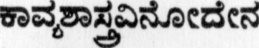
ಕಾವ್ಯಶಾಸ್ತ್ರವಿನೋದೇನ
